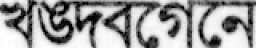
খঙদবগেনে
